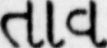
તાવ
